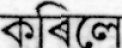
কৰিলে
